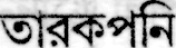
তারকপনি
